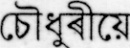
চৌধুৰীয়ে
